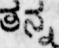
ತನ್ನ
